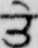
ਤੇ
